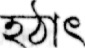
হঠাৎ
